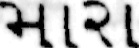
મારા
